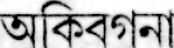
অকিবগনা
